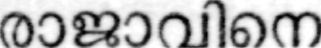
രാജാവിനെ
